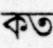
কত
